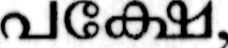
പക്ഷേ.
